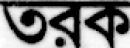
তরক
